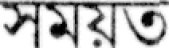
সময়ত
